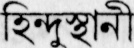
হিন্দুস্থানী
